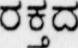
ರಕ್ತದ
